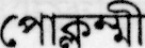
পোক্লম্মী
